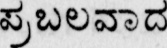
ಪ್ರಬಲವಾದ
